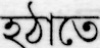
হঠাতে
